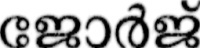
ജോര്‍ജ്
